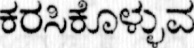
ಕರಸಿಕೊಳ್ಳುವ
